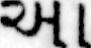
આ
